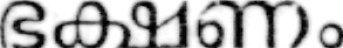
ഭക്ഷണം
